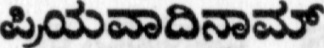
ಪ್ರಿಯವಾದಿನಾಮ್
